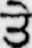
ਤੇ
